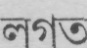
লগত
